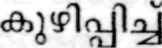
കുഴിപ്പിച്ച്
